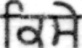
ਕਿਸੇ
